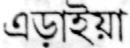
এড়াইয়া
